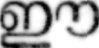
ഈ
